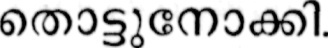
തൊട്ടുനോക്കി.
